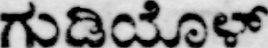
ಗುಡಿಯೊಳ್
